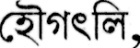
হৌগৎলি,
